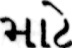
માટે
